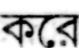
করে
